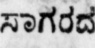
ಸಾಗರದ
